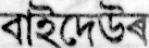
বাইদেউৰ
